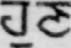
ਹੁਣ
